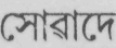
সোৱাদে
